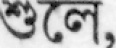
শুলে,
